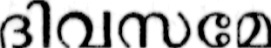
ദിവസമേ
